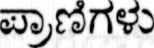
ಪ್ರಾಣಿಗಳು
